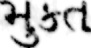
મુક્ત
